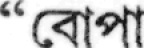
"বোপা
